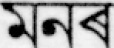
মনৰ
